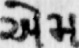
પણ
